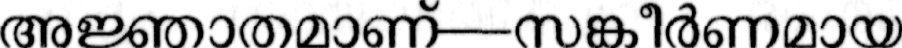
അജ്ഞാതമാണ്-സങ്കീര്‍ണമായ
